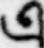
এ
